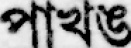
পাখঙ
